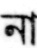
না
